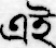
এই
